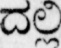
ದಲ್ಲಿ
